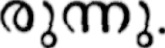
രുന്നു.
